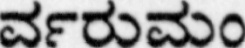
ರ್ವರುಮಂ
